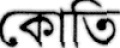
কোতি
